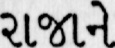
રાજાને
